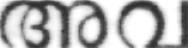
അവ
